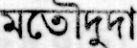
মতৌদুদা
